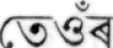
তেওঁৰ
